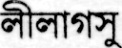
লীলাগসু
